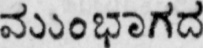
ಮುಂಭಾಗದ
